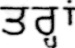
ਤਰ੍ਹਾਂ
